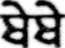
ਬੇਬੇ
